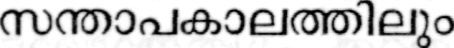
സന്താപകാലത്തിലും
